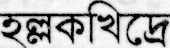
হল্লকখিদ্রে
